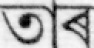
তাৰ
